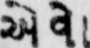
એવો
